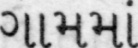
ગામમાં
